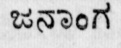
ಜನಾಂಗ
